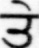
ਤੇ
